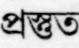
প্রস্তুত
